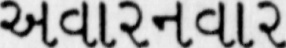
અવારનવાર
